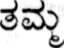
ತಮ್ಮ
